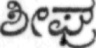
ಶೀಘ್ರ
